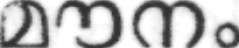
മൗനം
